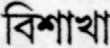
বিশাখা
